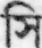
সি
